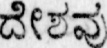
ದೇಶವು
